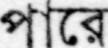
পারে
